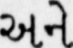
અને
